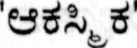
‘ಆಕಸ್ಮಿಕ’
